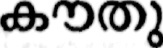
കൌതു
